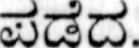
ಪಡೆದ.
